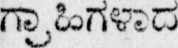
ಗ್ರಾಹಿಗಳಾದ
